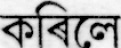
কৰিলে
